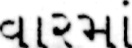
વારમાં
